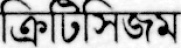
ক্রিটিসিজম
